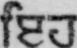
ਇਹ
